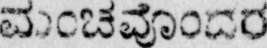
ಮಂಚವೊಂದರ
